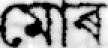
মোৰ
